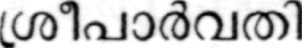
ശ്രീപാര്‍വതി
